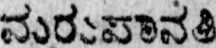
ಮರುಪಾವತಿ
